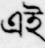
এই
